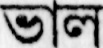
ভাল
